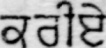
ਕਰੀਏ
